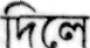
দিলে
